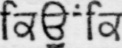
ਕਿਉਂਕਿ
